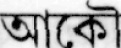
আকৌ
